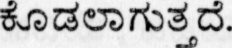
ಕೊಡಲಾಗುತ್ತದೆ.
